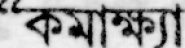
“কমাক্ষ্যা
